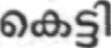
കെട്ടി
